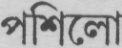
পশিলো
